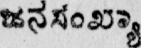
ಜನಸಂಖ್ಯಾ
